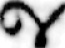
જ
